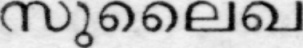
സുലൈഖ
